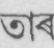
তাৰ
